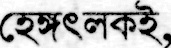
হেঙ্গৎলকই,
